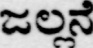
ಜಲ್ಲನೆ
